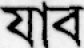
যাব
